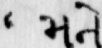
'મને
